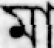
মা
